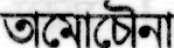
তামোচৌনা
